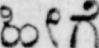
ಹೀಗೆ
